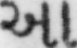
આ
